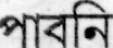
পাবনি
